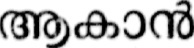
ആകാന്‍
